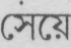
সেয়ে
